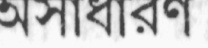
অসাধারণ
